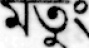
মতুং
